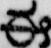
ಈ
